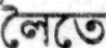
লৈতে
